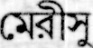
মেরীসু
